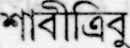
শাবীত্রিবা
